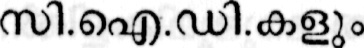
സി.ഐ.ഡി.കളും
